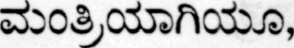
ಮಂತ್ರಿಯಾಗಿಯೂ,
